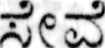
ಸೇವೆ
